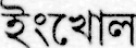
ইংখোল
